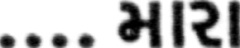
..........મારા
